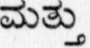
ಮತ್ತು
